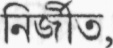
নির্জীত,
